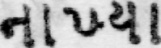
નાખ્યા
